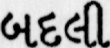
બદલી
